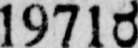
1971ರ
